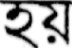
হয়
